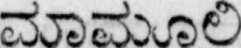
ಮಾಮೂಲಿ
